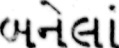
બનેલાં
